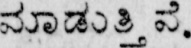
ಮಾಡುತ್ತಿವೆ.
